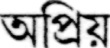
অপ্রিয়
